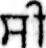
ਸੀ
